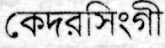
কেদরসিংগী
